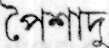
পৈশাদু
